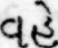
વહે
